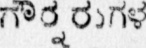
ಗೌರ್‍ನರುಗಳ
